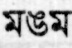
মঙম
